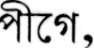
পীগে,
